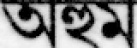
অহুম
